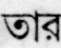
তার
